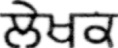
ਲੇਖਕ
